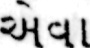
એવા
